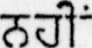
ਨਹੀਂ
